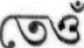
তেওঁ
